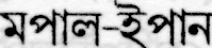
মপাল-ইপাল
